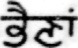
ਭੈਣਾਂ
